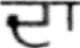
ਦਾ
